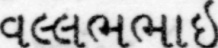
વલ્લભભાઈ
